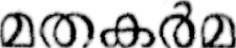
മതകര്‍മ
